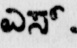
ಎಸ್.
